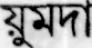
য়ুমদা
